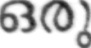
ഒരു
